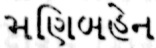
મણિબહેન
